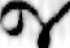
જ
